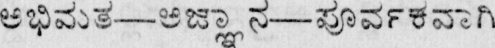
ಅಭಿಮತ-ಅಜ್ಞಾನ-ಪೂರ್ವಕವಾಗಿ
